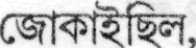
জোকাইছিল,
